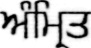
ਅੰਮ੍ਰਿਤ
